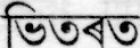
ভিতৰত
